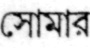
সোমার
